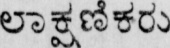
ಲಾಕ್ಷಣಿಕರು
